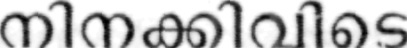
നിനക്കിവിടെ
